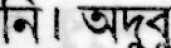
হায়জখ্রে,
